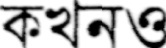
কখনও
